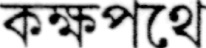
কক্ষপথে
